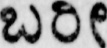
ಬರೀ
